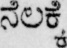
ನೆಲಕ್ಕೆ
